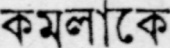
কমলাকে
